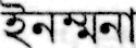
ইনম্মনা
